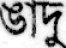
ঙাদু
